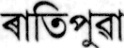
ৰাতিপুৱা
